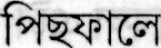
পিছফালে
